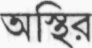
অস্থির
